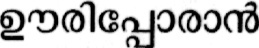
ഊരിപ്പോരാന്‍
